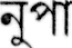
নুপা
